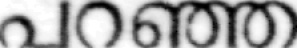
പറഞ്ഞ
